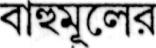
বাহুমূলের
